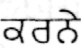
ਕਰਨੇ
